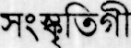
সংস্কতিগী
